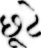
છૂટે
